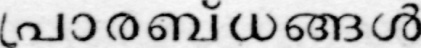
പ്രാരബ്ധങ്ങള്‍
